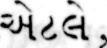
એટલે,
